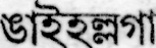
ঙাইহল্লগা
